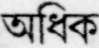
অধিক
